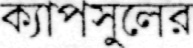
ক্যাপসুলের
